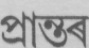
প্ৰান্তৰ
